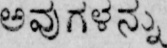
ಅವುಗಳನ್ನು
